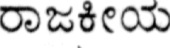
ರಾಜಕೀಯ
